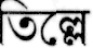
তিল্লে
